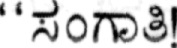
"ಸಂಗಾತಿ!
